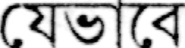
যেভাবে
